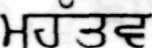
ਮਹੱਤਵ
